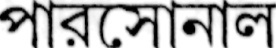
পারসোনাল
